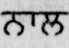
ਨਾਲ
